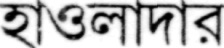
হাওলাদার
